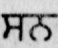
ਸਨ
